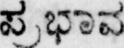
ಪ್ರಭಾವ
